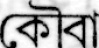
কৌবা
